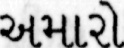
અમારો
